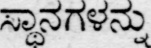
ಸ್ಥಾನಗಳನ್ನು
